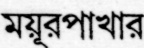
ময়ূরপাখার
